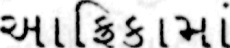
આફ્રિકામાં
